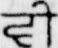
ਵੀ
